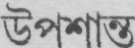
উপশান্ত
